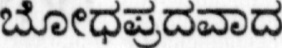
ಬೋಧಪ್ರದವಾದ
